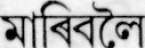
মাৰিবলৈ
